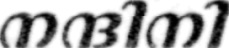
നന്ദിനി
